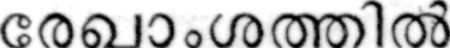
രേഖാംശത്തില്‍
